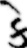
કે
